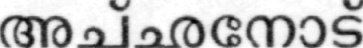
അച്ഛനോട്
